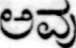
ಅವು
